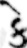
કે
